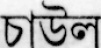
চাউল
